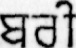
ਬਰੀ
